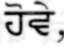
ਹੋਵੇ,
